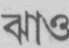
ঝাও
